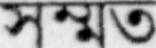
সম্মত
